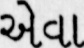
એવા
